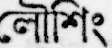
লৌশিং
